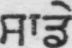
ਸਾਡੇ
